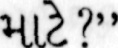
માટે?"
